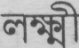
লক্ষ্মী
